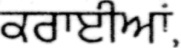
ਕਰਾਈਆਂ,
